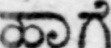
ಹಾಗೆ
